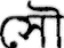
সৌ
